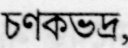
চণকভদ্র,
